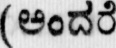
(ಅಂದರೆ
